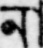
না
